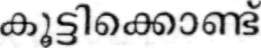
കൂട്ടിക്കൊണ്ട്
